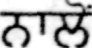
ਨਾਲੋਂ
